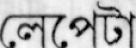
লেপেটা
